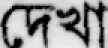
দেখা
